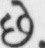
છે.
